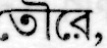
তৌরে,
